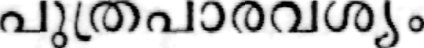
പുത്രപാരവശ്യം
